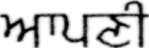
ਆਪਣੀ
